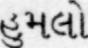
હુમલો
